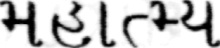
મહાત્મય
